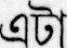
এটা
